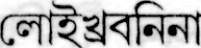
লোইখ্রবনিনা
